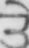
ਤੇ
